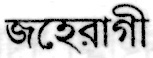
জরেহাগী
